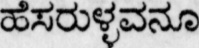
ಹೆಸರುಳ್ಳವನೂ
